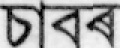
চাবৰ
